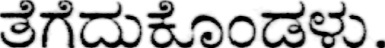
ತೆಗೆದುಕೊಂಡಳು.
